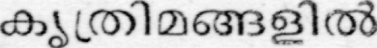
കൃത്രിമങ്ങളില്‍
